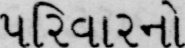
પરિવારનો
